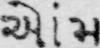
ઓંમ
